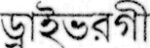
ড্রাইভরগী
